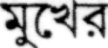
মুখের
